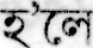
হ'লে
